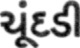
ચૂંદડી
